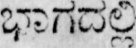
ಭಾಗದಲ್ಲಿ
